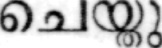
ചെയ്തു
